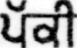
ਪੱਕੀ
